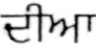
ਦੀਆ
